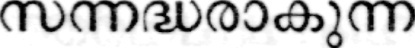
സന്നദ്ധരാകുന്ന
